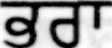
ਭਰਾ
